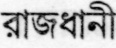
রাজধানী
